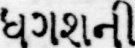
ધગશની
